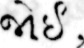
જોઈ,
